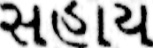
સહાય
